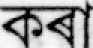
কৰা
